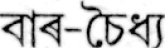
বাৰ-চৈধ্য
